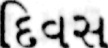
દિવસ
